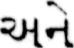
અને
